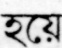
হয়ে
